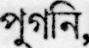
পুগনি,
